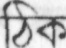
ঠিক
